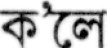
ক'লে
